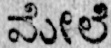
ಮೇಲೆ
